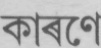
কাৰণে
